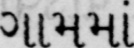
ગામમાં
